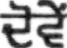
ਦੋਵੇਂ
